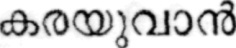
കരയുവാന്‍
